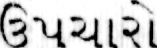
ઉપચારો
